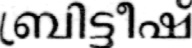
ബ്രിട്ടീഷ്
